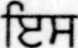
ਇਸ
